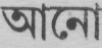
আনো
